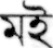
মই
